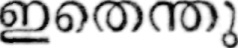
ഇതെന്തു
